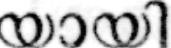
യായി
